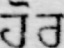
ਹੋਰ
